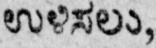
ಉಳಿಸಲು,
